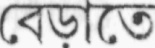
বেড়াতে
